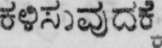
ಕಳಿಸುವುದಕ್ಕೆ
